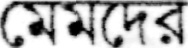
মেমদের
